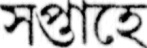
সপ্তাহে
